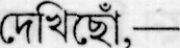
দেখিছোঁ,-
